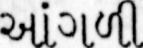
આંગળી
